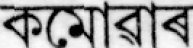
কমোৱাৰ
